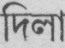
দিলা
